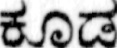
ಕೂಡ
